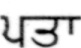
ਪਤਾ
